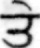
ਤੇ
